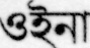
ওইনা
